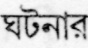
ঘটনার
